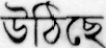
উঠিছে
